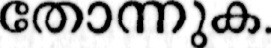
തോന്നുക.
